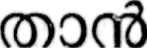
താന്‍
